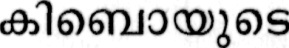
കിബൊയുടെ
